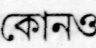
কোনও
